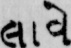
લાવે
